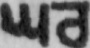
ਘਰ
